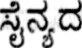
ಸೈನ್ಯದ
